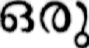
ഒരു
